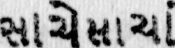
સાચેસાચાં
